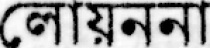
লোয়ননা
